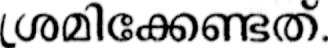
ശ്രമിക്കേണ്ടത്.
